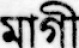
মাগী
